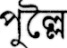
পুল্লৈ
